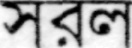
সরল
